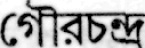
গৌরচন্দ্র
